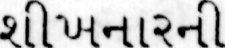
શીખનારની
